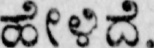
ಹೇಳಿದೆ.
